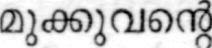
മുക്കുവന്റെ
